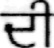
ਦੀ
